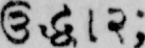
ઉદ્ધાર;
